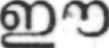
ഈ
